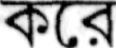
করে
